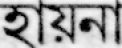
হায়না
